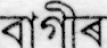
বাগীৰ
